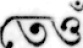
তেওঁ
